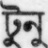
টুনু
